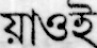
য়াওই
